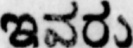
ಇವರು
